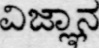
ವಿಜ್ಞಾನ
